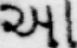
આ
